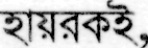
হায়রকই,
